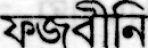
ফজবীনি
